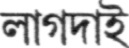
লাগদাই
